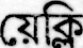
য়েক্লি
